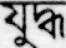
যুদ্ধ
